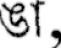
ঙা,
